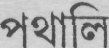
পথালি
